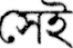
সেই
